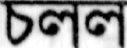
চলল
